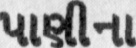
પાણીના
